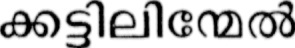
ക്കട്ടിലിന്മേല്‍
